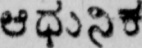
ಆಧುನಿಕ
